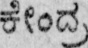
ಕೇಂದ್ರ
